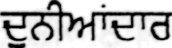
ਦੁਨੀਆਂਦਾਰ
